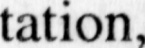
tation,
